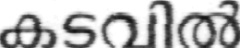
കടവില്‍
